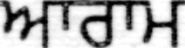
ਆਰਾਮ
